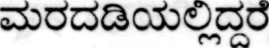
ಮರದಡಿಯಲ್ಲಿದ್ದರೆ
